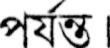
পর্যন্ত।
